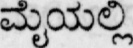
ಮೈಯಲ್ಲಿ
